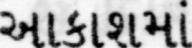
આકાશમાં
